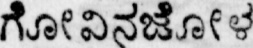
ಗೋವಿನಜೋಳ
